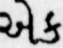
એક
